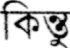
কিন্তু
